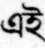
এই
